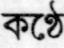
কণ্ঠে
